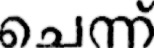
ചെന്ന്
